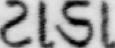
ટાડા
